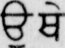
ਉਥੇ
